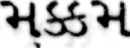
મક્કમ
